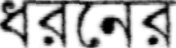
ধরনের
